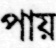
পায়
